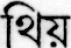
থিয়
